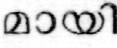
മായി
